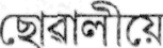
ছোৱালীয়ে
